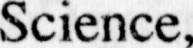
Science,
